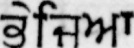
ਭੇਜਿਆ
